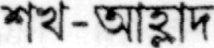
শখ-আহ্লাদ
